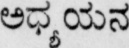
ಅಧ್ಯಯನ
